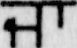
ਜਾ
